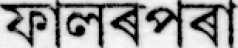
ফালৰপৰা
